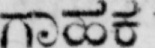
ಗಾಹಕ
